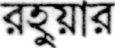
রহুয়ার
